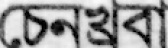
চেনখ্রবা
